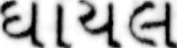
ઘાયલ
